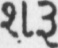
શરૂ
